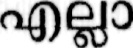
എല്ലാ
